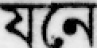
যনে
